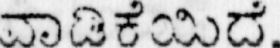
ವಾಡಿಕೆಯಿದೆ.
